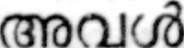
അവള്‍
